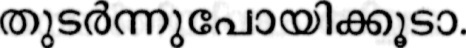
തുടര്‍ന്നുപോയിക്കൂടാ.
